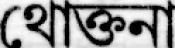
থোক্তনা
